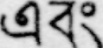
এবং
